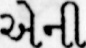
એની
